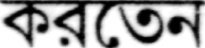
করতেন
